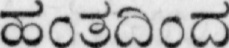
ಹಂತದಿಂದ
